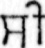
ਸੀ
